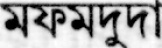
মফমদুদা
